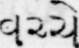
વચ્ચે
